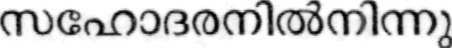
സഹോദരനില്‍നിന്നു
